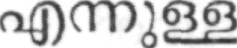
എന്നുള്ള
